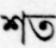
শত
